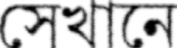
সেখানে
